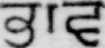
ਭਾਵ
